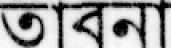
তাবনা
